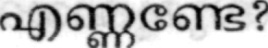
എണ്ണണ്ടേ?
